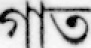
গাত
